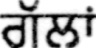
ਗੱਲਾਂ
